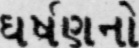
ઘર્ષણનો
